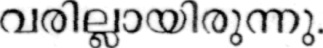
വരില്ലായിരുന്നു.
